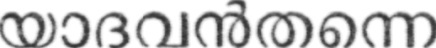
യാദവന്‍തന്നെ
